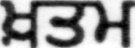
ਖ਼ਤਮ
